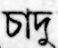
চাদু
